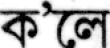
ক'লে
